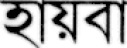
হায়বা
